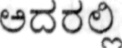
ಅದರಲ್ಲಿ
